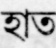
হাত
